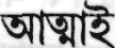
আত্মাই
